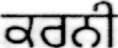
ਕਰਨੀ
